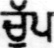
ਚੁੱਪ
